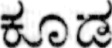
ಕೂಡ
